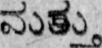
ಮತ್ತು
